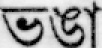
ভঙা
